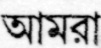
আমরা
